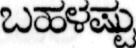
ಬಹಳಷ್ಟು
